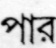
পার
